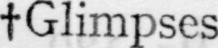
Glimpses
